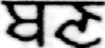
ਬਣ
